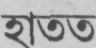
হাতত
